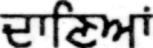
ਦਾਣਿਆਂ
